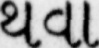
થવા
